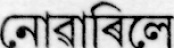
নোৱাৰিলে
